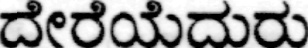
ದೇರೆಯೆದುರು
